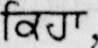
ਕਿਹਾ,
